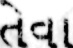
તેવા
